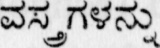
ವಸ್ತ್ರಗಳನ್ನು
